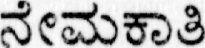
ನೇಮಕಾತಿ
